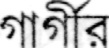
গার্গীর
